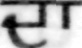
ਦਾ
